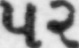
પર
